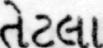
તેટલા
